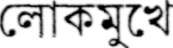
লোকমুখে
